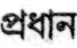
প্রধান
